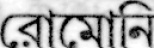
রোমোনি
